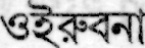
ওইরুবনা
